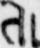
તો
